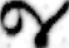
જ
